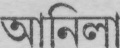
আনিলা
